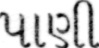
પાણી
